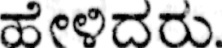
ಹೇಳಿದರು.
